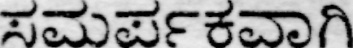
ಸಮರ್ಪಕವಾಗಿ
